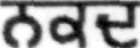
ਨਕਦ
